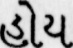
હોય
